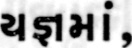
યજ્ઞમાં,
